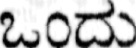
ಒಂದು
